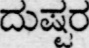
ದುಷ್ಟರ
